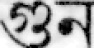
গুন
